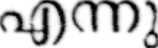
എന്നു
